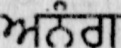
ਅਨੰਗ
